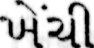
ખેંચી
